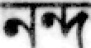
নন্দ
